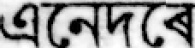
এনেদৰে
